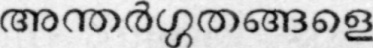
അന്തര്‍ഗ്ഗതങ്ങളെ
